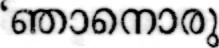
‘ഞാനൊരു
